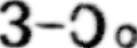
3-ാം
